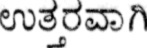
ಉತ್ತರವಾಗಿ
